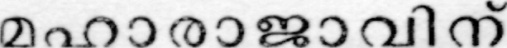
മഹാരാജാവിന്
